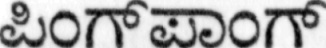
ಪಿಂಗ್ ಪಾಂಗ್
